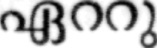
ഏററു
